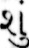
શું
